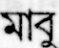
মাবু
